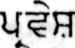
ਪ੍ਰਵੇਸ਼
